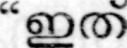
"ഇത്
